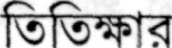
তিতিক্ষার
